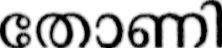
തോണി
